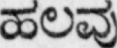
ಹಲವು
